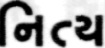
નિત્ય
